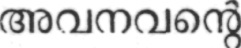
അവനവന്റെ
